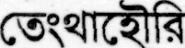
তেংথাহৌরি
